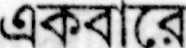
একবারে
